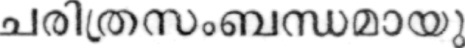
ചരിത്രസംബന്ധമായു
